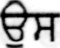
ਉਸ
